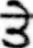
ਤੇ
